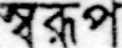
স্বরূপ
